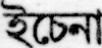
ইচেনা
